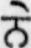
ਨੇ
